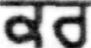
ਕਰ
